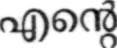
എന്റെ
